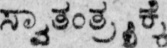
ಸ್ವಾತಂತ್ರ್ಯಕ್ಕೆ
